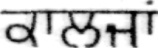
ਕਾਲਜਾਂ
